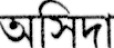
অসিদা
